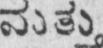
ಮತ್ತು
